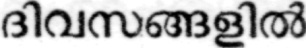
ദിവസങ്ങളില്‍
